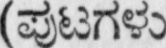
(ಪುಟಗಳು
